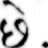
છે.
